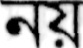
নয়
